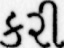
કરી
